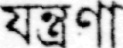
যন্ত্রণা
